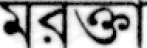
মরক্তা
